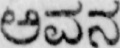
ಅವನ
